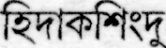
হিদাকশিংদু
